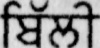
ਬਿੱਲੀ
